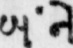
બંને
